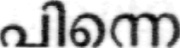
പിന്നെ
